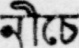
নীচে
